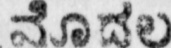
ಮೊದಲ
